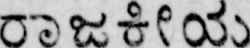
ರಾಜಕೀಯ
